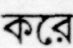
করে
